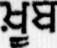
ਖ਼ੂਬ
